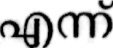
എന്ന്
